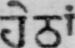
ਹੇਠਾਂ
